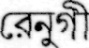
রেনুগী
